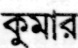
কুমার
